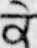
ਕੇ
